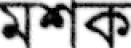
মশক
